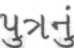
પુત્રનું
